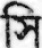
সি
